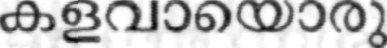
കളവായൊരു
